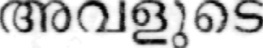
അവളുടെ
